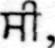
ਸੀ,
